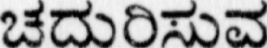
ಚದುರಿಸುವ
